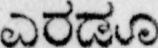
ಎರಡೂ
